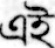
এই
